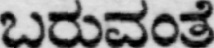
ಬರುವಂತೆ
